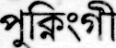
পুক্নিংগী
